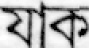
যাক
